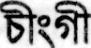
চীংগী
